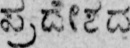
ಪ್ರದೇಶದ
